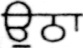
ਉਠਾ
